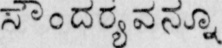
ಸೌಂದರ್‍ಯವನ್ನೂ
